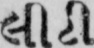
લીટી
